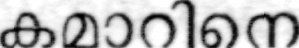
കമാറിനെ
